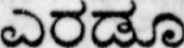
ಎರಡೂ
